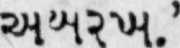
અબરખ.'
